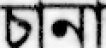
চানা
